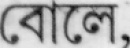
বোলে,
